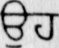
ਉਹ
